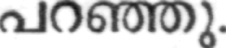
പറഞ്ഞു.
